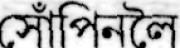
সোঁপিনলৈ
